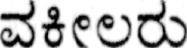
ವಕೀಲರು
